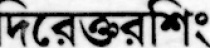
দিরেক্তরশিং
